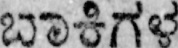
ಬಾಕಿಗಳ
